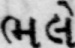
ભલે
